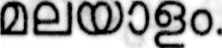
മലയാളം.
